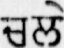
ਚਲੇ
